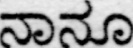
ನಾನೂ
